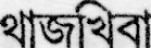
থাজখিবা
